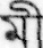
মী
